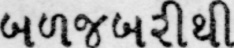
બળજબરીથી
